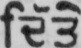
ਦਿੱਤੇ
